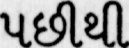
પછીથી
